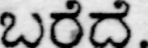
ಬರೆದೆ.
